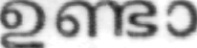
ഉണ്ടാ
